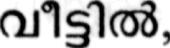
വീട്ടില്‍,
